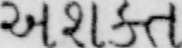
અશક્ત
